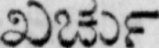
ಖರ್ಚು
